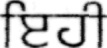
ਇਹੀ
